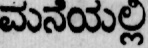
ಮನೆಯಲ್ಲಿ
